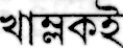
খাম্লকই
